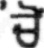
'ਚੋਂ
